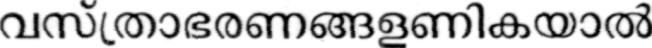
വസ്ത്രാഭരണങ്ങളണികയാല്‍
